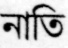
নাতি
